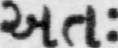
અતઃ
